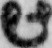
ಆ
